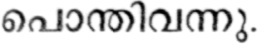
പൊന്തിവന്നു.
